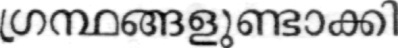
ഗ്രന്ഥങ്ങളുണ്ടാക്കി
